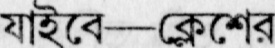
যাইবে-ক্লেশের
